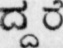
ದ್ದರೆ
